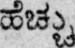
ಹೆಚ್ಚು
